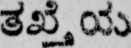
ತಖ್ತೆಯ
